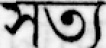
সত্য
